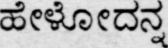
ಹೇಳೊದನ್ನ
